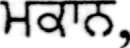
ਮਕਾਨ,
